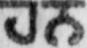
ਹਨ
